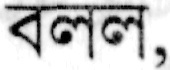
বলল,
